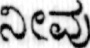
ನೀವು
